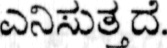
ಎನಿಸುತ್ತದೆ.
